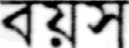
বয়স
